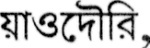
য়াওদৌরি,
